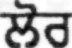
ਲੋਰ
